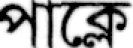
পাক্লে
